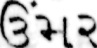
ઉંમર
